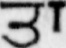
ਤਾਂ
